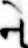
ને
